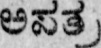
ಅಪತ್ರ
